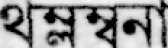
থম্লম্বনা
